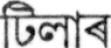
টিলাৰ
